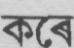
কৰে
